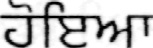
ਹੋਇਆ
